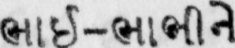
ભાઈ-ભાભીને
